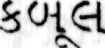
કબૂલ
